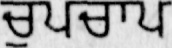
ਚੁਪਚਾਪ
